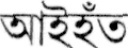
আইহঁত
